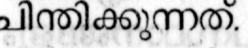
ചിന്തിക്കുന്നത്.
